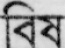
বিষ
